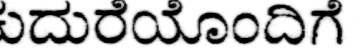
ಕುದುರೆಯೊಂದಿಗೆ
